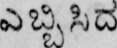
ಎಬ್ಬಿಸಿದ
